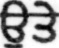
ਉਤੇ
